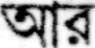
আর
